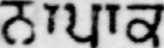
ਨਾਪਾਕ
